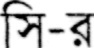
সি-র
